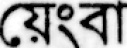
য়েংবা
